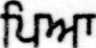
ਪਿਆ
